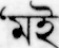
'মই
